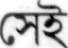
সেই
